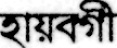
হায়বগী
